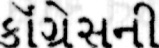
કૉંગ્રેસની
